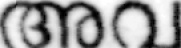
അവ
